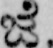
ಜೆ.
